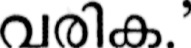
വരിക.'
